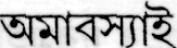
অমাবস্যাই
